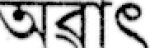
অৱাৎ
